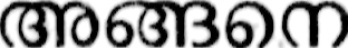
അങ്ങനെ
